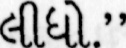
લીધો."
